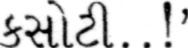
કસોટી..!'
